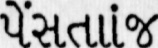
પેંસતાાંજ
